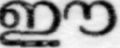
ഈ
